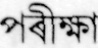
পৰীক্ষা
